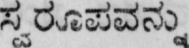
ಸ್ವರೂಪವನ್ನು
